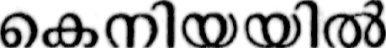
കെനിയയില്‍
